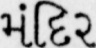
મંદિર
